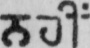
ਨਹੀਂ
